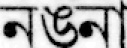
নঙনা
